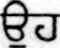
ਉਹ
